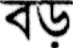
বড়
